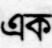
এক
